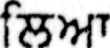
ਲਿਆ
